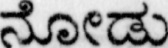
ನೋಡು
